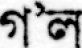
গ'ল
